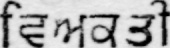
ਵਿਅਕਤੀ
